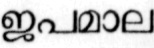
ജപമാല
